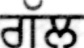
ਗੱਲ
